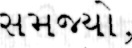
સમજ્યો,
